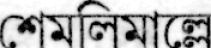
শেমলিমাল্লে
